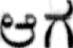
ಆಗ
